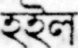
হইল
